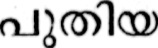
പുതിയ
